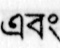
এবং
